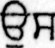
ਉਸ
